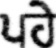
ਪਹੇ
